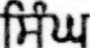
ਸਿੰਘ
